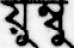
য়ুম্বু
